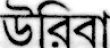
উরিবা
